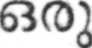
ഒരു
